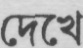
দেখে
